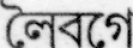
লৈবগে
